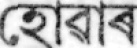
হোৱাৰ
